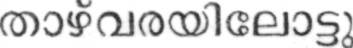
താഴ്വരയിലോട്ടു
